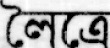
লৈত্রে
